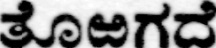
ತೊಱಗದೆ
